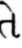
તે
